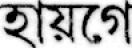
হায়গে
